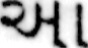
આ
